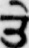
ਤੇ
